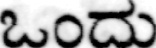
ಒಂದು
